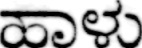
ಹಾಳು
